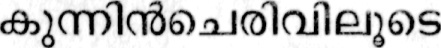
കുന്നിന്‍ചെരിവിലൂടെ
